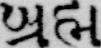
બ્રહ્મ
